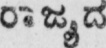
ರಾಜ್ಯದ
